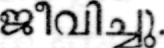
ജീവിച്ചു.
